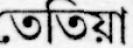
তেতিয়া
